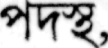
পদস্থ,
